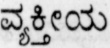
ವ್ಯಕ್ತೀಯ
